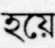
হয়ে
